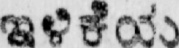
ಇಳಿಕೆಯ
